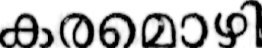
കരമൊഴി
